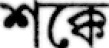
শক্কে
